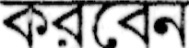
করবেন
